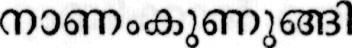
നാണംകുണുങ്ങി
